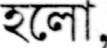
হলো,
